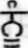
ਨੂੰ
